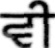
ਵੀ
